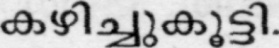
കഴിച്ചുകൂട്ടി.
